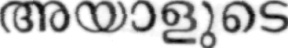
അയാളുടെ
